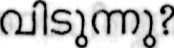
വിടുന്നു?
